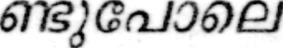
ണ്ടുപോലെ
